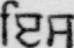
ਇਸ
